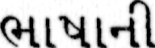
ભાષાની
